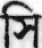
সি
